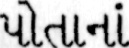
પોતાનાં
